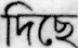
দিছে
